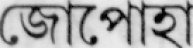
জোপোহা
